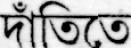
দাঁতিতে
